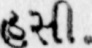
હસી.
